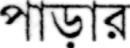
পাড়ার
